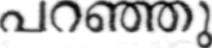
പറഞ്ഞു
